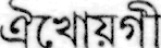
ঐখোয়গী
